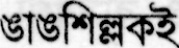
ঙাঙশিল্লকই
